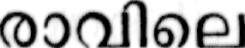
രാവിലെ
